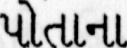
પોતાના
